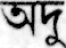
অদু
